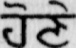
ਹੋਣੇ
